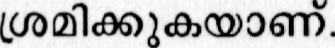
ശ്രമിക്കുകയാണ്.
